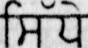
ਸਿੱਧੇ
